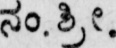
ನಂ.ಶ್ರೀ.
